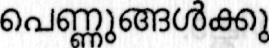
പെണ്ണുങ്ങള്‍ക്കു
